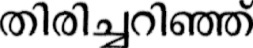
തിരിച്ചറിഞ്ഞ്
